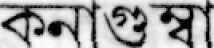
কনাগুম্বা
